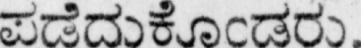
ಪಡೆದುಕೊಂಡರು.
